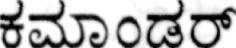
ಕಮಾಂಡರ್
